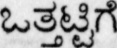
ಒತ್ತಟ್ಟಿಗೆ
